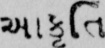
આકૃતિ
